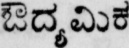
ಔದ್ಯಮಿಕ
